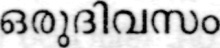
ഒരുദിവസം
